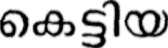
കെട്ടിയ
